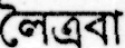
লৈত্রবা
